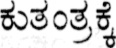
ಕುತಂತ್ರಕ್ಕೆ
